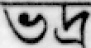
ভদ্র
